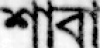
শাবা
